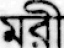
মরী
